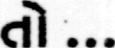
તો......
